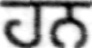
ਹਨ
